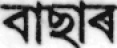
বাছাৰ
